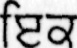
ਇਕ
